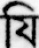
যি
